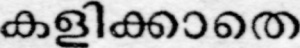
കളിക്കാതെ
